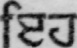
ਇਹ
